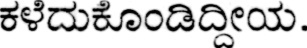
ಕಳೆದುಕೊಂಡಿದ್ದೀಯ.
